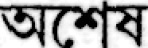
অশেষ
